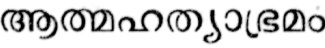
ആത്മഹത്യാഭ്രമം
